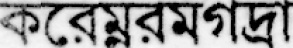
করেম্নরমগদ্রা
